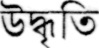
উদ্ধৃতি
